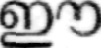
ഈ
